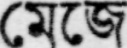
মেজে
